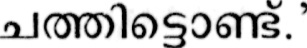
ചത്തിട്ടൊണ്ട്.’
